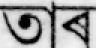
তাৰ
